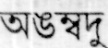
অঙম্বদু
